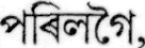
পৰিলগৈ,
